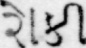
રોકી
